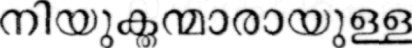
നിയുക്തന്മാരായുള്ള
